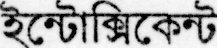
ইন্টোক্সিকেন্ট
